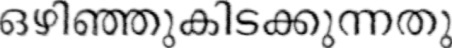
ഒഴിഞ്ഞുകിടക്കുന്നതു
